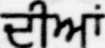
ਦੀਆਂ
